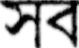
সব
